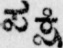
ಪಕ್ಷಿ
